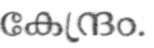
കേന്ദ്രം.
